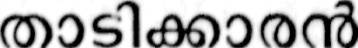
താടിക്കാരന്‍
